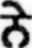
ਨੇ
